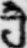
ਹੈ
